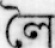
লৈ
